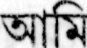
আমি
